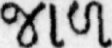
જાળ
